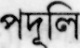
পদূলি
